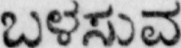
ಬಳಸುವ
